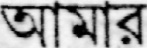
আমার
